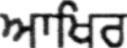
ਆਖਿਰ
